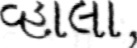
વ્હાલા,
